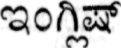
ಇಂಗ್ಲಿಷ್
